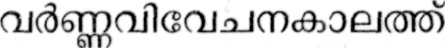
വര്‍ണ്ണവിവേചനകാലത്ത്
